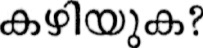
കഴിയുക?
